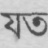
যত
